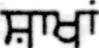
ਸ਼ਾਖਾਂ
